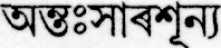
অন্তঃসাৰশূন্য
